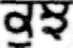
ਕੁਝ
